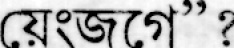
য়েংজগে”?
